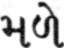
મળે
